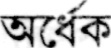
অর্ধেক
